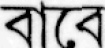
বাবে
